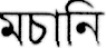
মচানি
